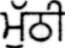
ਮੁੱਠੀ
